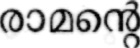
രാമന്റെ
